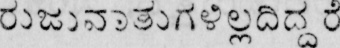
ರುಜುವಾತುಗಳಿಲ್ಲದಿದ್ದರೆ
